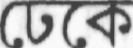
ঢেকে
